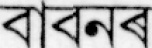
বাবনৰ
